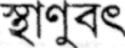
স্থাণুবৎ
